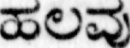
ಹಲವು
